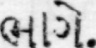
ભાગે.
